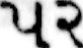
પર
